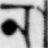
না
